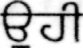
ਉਹੀ
